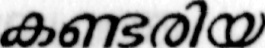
കണ്ടരിയ
